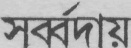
সৰ্ব্বদায়
